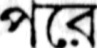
পরে
